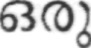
ഒരു
